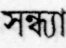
সন্ধ্যা
